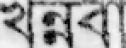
খন্নবা
